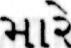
મારે
